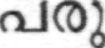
പരു
